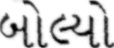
બોલ્યો
